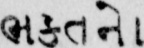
ભક્તનો
